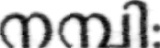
നമ്പി:
